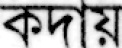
কদায়
